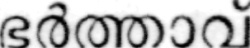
ഭര്‍ത്താവ്
